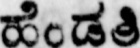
ಹೆಂಡತಿ
